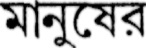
মানুষের
